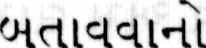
બતાવવાનો
